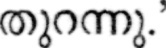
തുറന്നു.’
